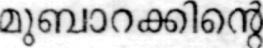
മുബാറക്കിന്റെ
